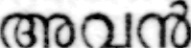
അവന്‍
